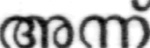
അന്ന്
